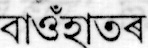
বাওঁহাতৰ
